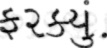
ફરક્યું.
